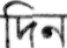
দিন
